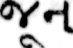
જૂન
